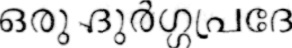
ഒരുദുര്‍ഗ്ഗപ്രദേ
